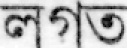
লগত
